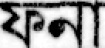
ফনা
